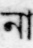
না
